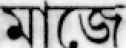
মাজে
